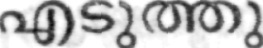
എടുത്തു
